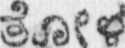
ತೋಳ
